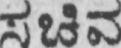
ಸಚಿವ
